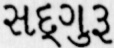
સદગુરૂ
